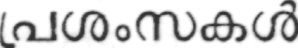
പ്രശംസകള്‍
